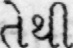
તેથી
